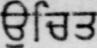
ਉਚਿਤ
